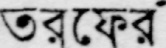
তরফের
